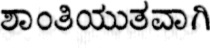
ಶಾಂತಿಯುತವಾಗಿ
